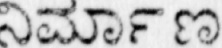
ನಿರ್ಮಾಣ
